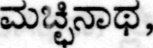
ಮಚ್ಛಿನಾಥ,
